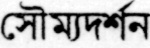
সৌম্যদর্শন
